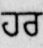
ਹਰ
